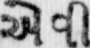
એવી
